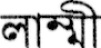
লাম্মী
